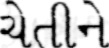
ચેતીને
